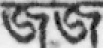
জজ
